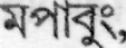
মপাবুং,
